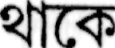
থাকে
